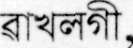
ৱাখলগী,
